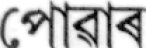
পোৱাৰ
